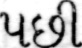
પછી
